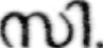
സി.
